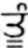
ਤੂੰ
